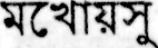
মখোয়সু
